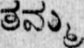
ತಮ್ಮ
